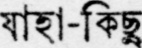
যাহা-কিছু
